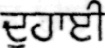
ਦੁਹਾਈ
